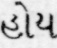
હોય
